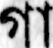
গা
